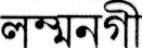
লম্মনগী
